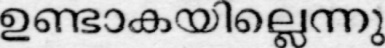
ഉണ്ടാകയില്ലെന്നു
